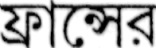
ফ্রান্সের
